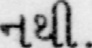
નથી.
